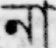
না
